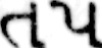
તપ
